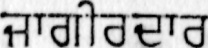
ਜਾਗੀਰਦਾਰ
